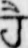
ਹੈ
